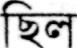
ছিল
